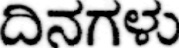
ದಿನಗಳು
